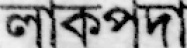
লাকপদা
